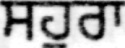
ਸਹੁਰਾ
